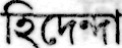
হিদেন্দা
